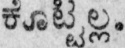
ಕೊಟ್ಟಿಲ್ಲ.
